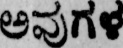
ಅವುಗಳ
